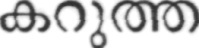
കറുത്ത
